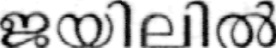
ജയിലില്‍
